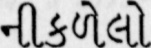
નીકળેલો
